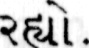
રહ્યો.
